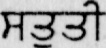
ਸਤੁਤੀ
